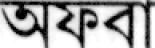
অফবা
